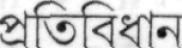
প্ৰতিবিধান
